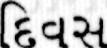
દિવસ
